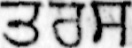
ਤਰਸ
